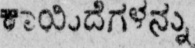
ಕಾಯಿದೆಗಳನ್ನು
